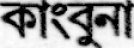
কাংবুনা
